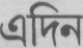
এদিন
